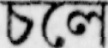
চলে
